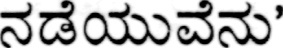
ನಡೆಯುವೆನು'
